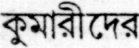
কুমারীদের
